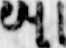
બા
